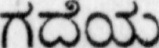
ಗದೆಯ
